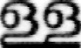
ള്ള
